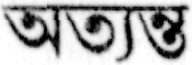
অত্যন্ত
